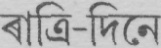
ৰাত্ৰি-দিনে
